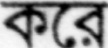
করে
